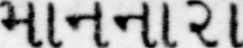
માનનારા
